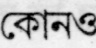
কোনও
